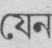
যেন
